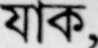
যাক,
